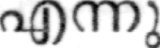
എന്നു
